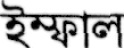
ইম্ফাল
